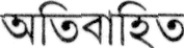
অতিবাহিত
